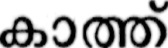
കാത്ത്
